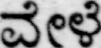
ವೇಳೆ
